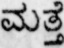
ಮತ್ತೆ
